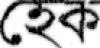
হেক
